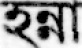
হন্না
